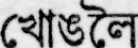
খোঙলৈ
